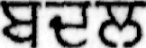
ਬਦਲ
